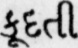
કૂદતી
